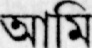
আমি
